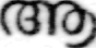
ആ
